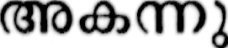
അകന്നു
